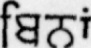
ਬਿਨਾਂ
